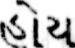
હોય
